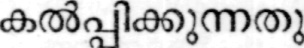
കല്‍പ്പിക്കുന്നതു
